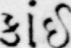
કાંઈ
